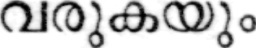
വരുകയും
